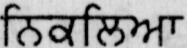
ਨਿਕਲਿਆ
